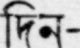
দিন-
